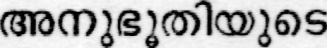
അനുഭൂതിയുടെ
